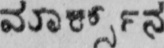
ಮಾರ್ಕ್ಸ್ ನ
